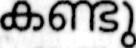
കണ്ടു
